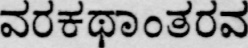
ವರಕಥಾಂತರವ
